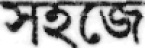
সহজে
